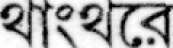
থাংথরে
